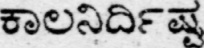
ಕಾಲನಿರ್ದಿಷ್ಟ
